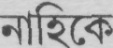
নাহিকে
